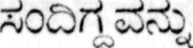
ಸಂದಿಗ್ದವನ್ನು
